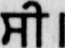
ਸੀ।
